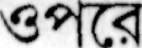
ওপরে
